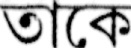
তাকে
